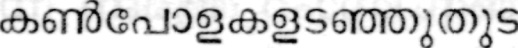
കണ്‍പോളകളടഞ്ഞുതുട
